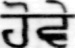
ਹੋਵੇ
